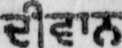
ਦੀਵਾਨ
